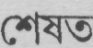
শেষত
